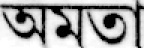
অমদা
